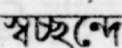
স্বচ্ছন্দে
